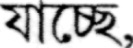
যাচ্ছে,
